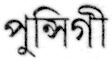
পুন্সিগী
